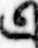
এ
